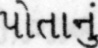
પોતાનું
